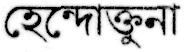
হেন্দোক্তুনা
